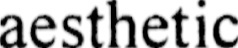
aesthetic
